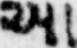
આ
